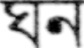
ঘন
